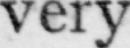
very
